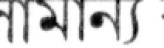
সামান্য
